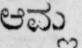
ಆಮ್ಲ
